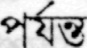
পর্যন্ত
